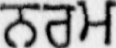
ਨਰਮ
